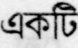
একটি
